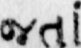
જતાં
